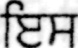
ਇਸ
